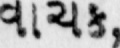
વાચક,
